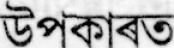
উপকাৰত
